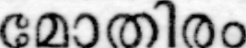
മോതിരം
